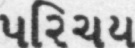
પરિચય
